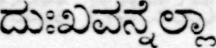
ದುಃಖವನ್ನೆಲ್ಲಾ
